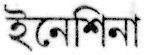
ইনেশিনা
